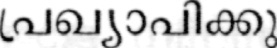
പ്രഖ്യാപിക്കു
